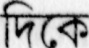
দিকে
